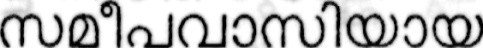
സമീപവാസിയായ
